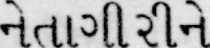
નેતાગીરીને
